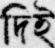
দিই
